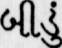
બીડું
